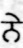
ਨੇ
